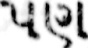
પણ
